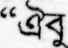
“ঐবু
